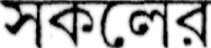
সকলের
